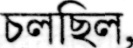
চলছিল,
